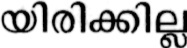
യിരിക്കില്ല
